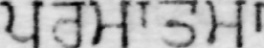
ਪਰਮਾਤਮਾ
